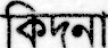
কিদনা
